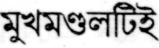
মুখমণ্ডলটিই
